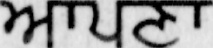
ਆਪਣਾ
